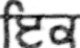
ਇਕ
